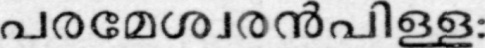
പരമേശ്വരന്‍പിള്ള:
